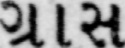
ગ્રાસ
